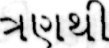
ત્રણથી
